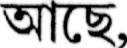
আছে,
